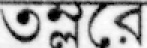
তম্লরে
